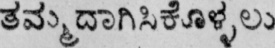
ತಮ್ಮದಾಗಿಸಿಕೊಳ್ಳಲು
